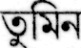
তুমিন
